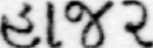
હાજર
